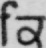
ਕਿ
